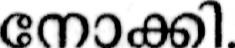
നോക്കി.
